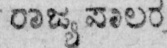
ರಾಜ್ಯಪಾಲರ
